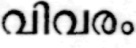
വിവരം
